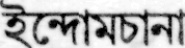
ইন্দোমচানা
